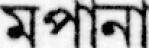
মপানা
